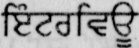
ਇੰਟਰਵਿਊ
